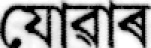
যোৱাৰ
